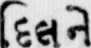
દિલને
